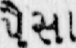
પૈસા
